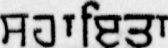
ਸਹਾਇਤਾ
